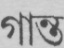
গান্ত
